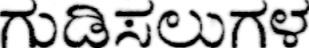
ಗುಡಿಸಲುಗಳ
